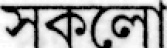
সকলো
